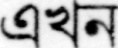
এখন
